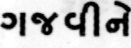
ગજવીને
